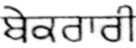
ਬੇਕਰਾਰੀ
